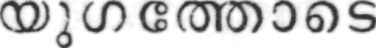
യുഗത്തോടെ
